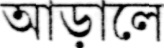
আড়ালে
